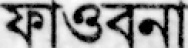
ফাওবনা
